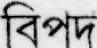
বিপদ
